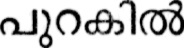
പുറകില്‍
